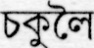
চকুলৈ
